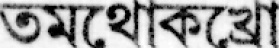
তমথোকখ্রো
